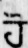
ਹੋ
